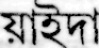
য়াইদা
